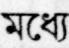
মধ্যে
